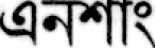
এনশাং
